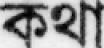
কথা
